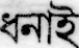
ধনাই
